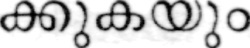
ക്കുകയും
